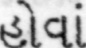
હોવાં
